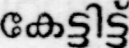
കേട്ടിട്ട്
